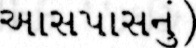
આસપાસનું)
